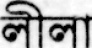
লীলা
